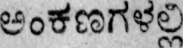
ಅಂಕಣಗಳಲ್ಲಿ
